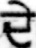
ਦੇ
